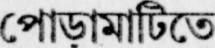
পোড়ামাটিতে
